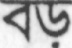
বড়
